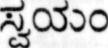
ಸ್ವಯಂ
